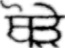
ਥੋੜੇ
